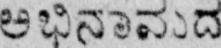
ಅಭಿನಾಮದ
